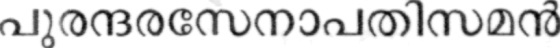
പുരന്ദരസേനാപതിസമന്‍
